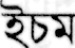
ইচম
